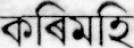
কৰিমহি
